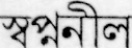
স্বপ্ননীল
